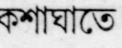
কশাঘাতে
